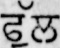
ਫੁੱਲ
